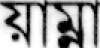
য়াম্না
